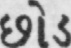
છોડ
